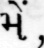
મેં,
